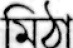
মিঠা
